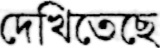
দেখিতেছে
